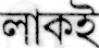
লাকই
